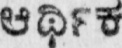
ಆರ್ಥಿಕ
